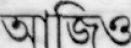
আজিও
